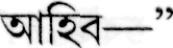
আহিব-"
